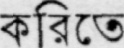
করিতে
